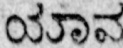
ಯಾವ
